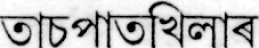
তাচপাতখিলাৰ
